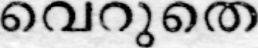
വെറുതെ
